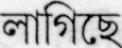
লাগিছে
